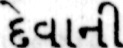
દેવાની
